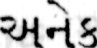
અનેક
